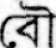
বৌ
